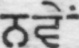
ਨਵੇਂ
